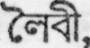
লৈবী,
